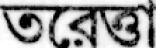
তরেত্তা
